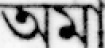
অমা
